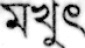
মখুৎ
